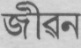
জীৱন
